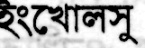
ইংখোলসু
